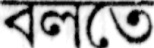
বলতে
